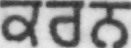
ਕਰਨ
